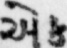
એક
